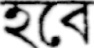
হবে
